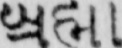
બ્રહ્મા
